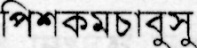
পিশকমচাবুসু
